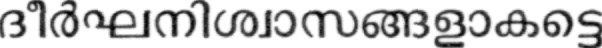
ദീര്‍ഘനിശ്വാസങ്ങളാകട്ടെ
